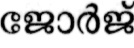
ജോര്‍ജ്
